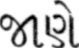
જાણે
